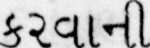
કરવાની
